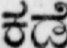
ಕಡೆ
